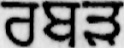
ਰਬੜ
